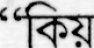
"কিয়
